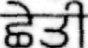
ਛੇਤੀ
